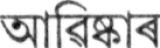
আৱিষ্কাৰ
